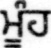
ਮੂੰਹ
